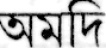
অমদি
